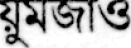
য়ুমজাও
